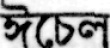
ঈচেল
